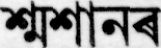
শ্মশানৰ
